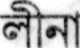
লীনা
